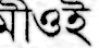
মীওই
